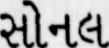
સોનલ
